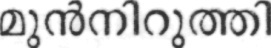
മുന്‍നിറുത്തി
